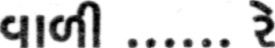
વાળી......રે
